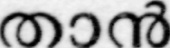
താന്‍
